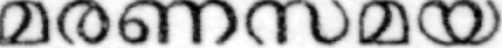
മരണസമയ
